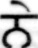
ਨੇ
